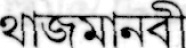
কার
